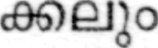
ക്കലും
